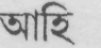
আহি
